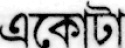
একোটা
